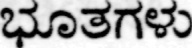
ಭೂತಗಳು
